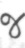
જ
